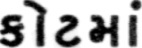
કોટમાં
